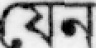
যেন
